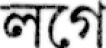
লগে
